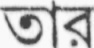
তার
